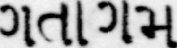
ગતાગમ
